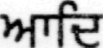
ਆਦਿ
